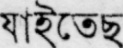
যাইতেছ
